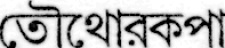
তৌথোরকপা
